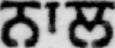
ਨਾਲ
